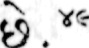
છે.૪૯
